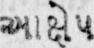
આક્ષેપ
